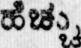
ಹೆಚ್ಚು
